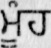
ਮੂੰਹ
